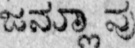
ಜಮ್ಲಾವು
